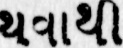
થવાથી
